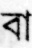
বা
